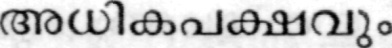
അധികപക്ഷവും
